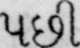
પછી
